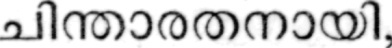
ചിന്താരതനായി,
